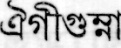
ঐগীগুম্না
